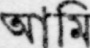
আমি
